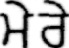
ਮੇਰੇ
